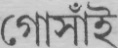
গোসাঁই
